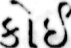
કોઈ
